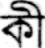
কী
